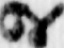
જ
